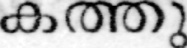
കത്തു
